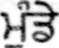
ਮੁੰਡੇ
